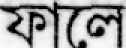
ফালে
